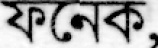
ফনেক,
